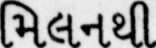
મિલનથી
